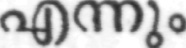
എന്നും
